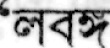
‘লবঙ্গ
